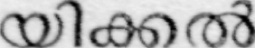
യിക്കല്‍
